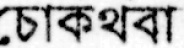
চোকথবা
